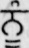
ਨੂੰ
